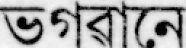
ভগৱানে
